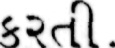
કરતી.
